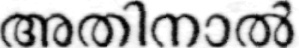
അതിനാല്‍
